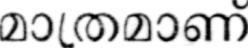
മാത്രമാണ്
